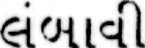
લંબાવી
